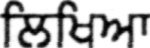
ਲਿਖਿਆ
